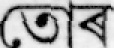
তোৰ
